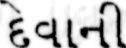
દેવાની
